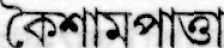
কৈশামপাত্তা
